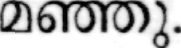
മഞ്ഞു.
